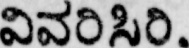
ವಿವರಿಸಿರಿ.
